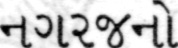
નગરજનો
